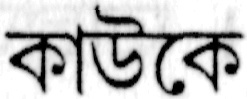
কাউকে
